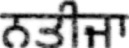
ਨਤੀਜਾ
